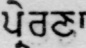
ਪ੍ਰੇਰਣਾ
